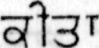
ਕੀਤਾ
